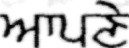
ਆਪਣੇ
